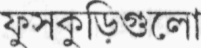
ফুসকুড়িগুলো
